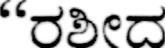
"ರಶೀದ
